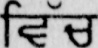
ਵਿੱਚ
